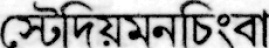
স্টেদিয়মনচিংবা
